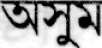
অসুম
